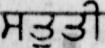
ਸਤੁਤੀ
